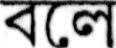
বলে
